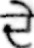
ਦੇ
